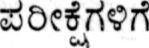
ಪರೀಕ್ಷೆಗಳಿಗೆ
